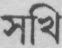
সখি
